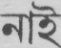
নাই
